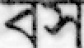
বস
